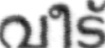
വീട്
